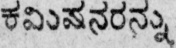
ಕಮಿಷನರನ್ನು
